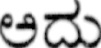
ಅದು
